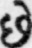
છે
